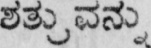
ಶತ್ರುವನ್ನು
